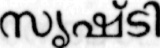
സൃഷ്ടി
